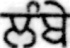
ਲੰਬੇ
